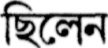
ছিলেন
